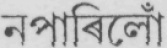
নপাৰিলোঁ
